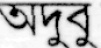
অদুবু
